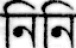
নিনি
